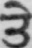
ਤੇ
